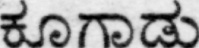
ಕೂಗಾಡು
